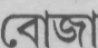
বোজা
